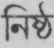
নিষ্ঠ
